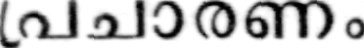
പ്രചാരണം
